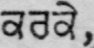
ਕਰਕੇ,
